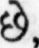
છે,
